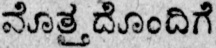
ಮೊತ್ತದೊಂದಿಗೆ
